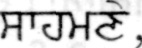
ਸਾਹਮਣੇ,
